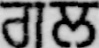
ਗਲ
